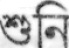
শুনি
